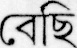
বেছি
